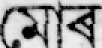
মোৰ
